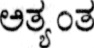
ಅತ್ಯಂತ
